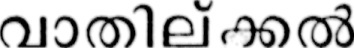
വാതില്ക്കല്‍
